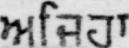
ਅਜਿਹਾ
